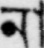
না
